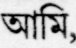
আমি,
